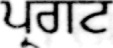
ਪ੍ਰਗਟ
